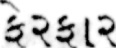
ફેરફાર
